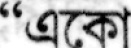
"একো
